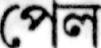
পেল
